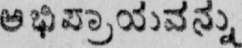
ಅಭಿಪ್ರಾಯವನ್ನು
